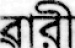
ৱারী
